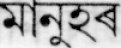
মানুহৰ
